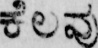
ಕೆಲವು
